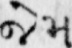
જેમ
